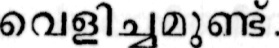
വെളിച്ചമുണ്ട്.
